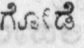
ಗೋಡೆ
